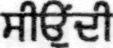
ਸੀਉਂਦੀ
